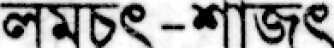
লমচৎ-শাজৎ
